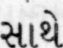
સાથે
